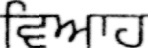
ਵਿਆਹ
